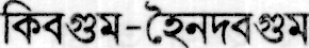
কিবগুম-হৈনদবগুম
